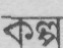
কল্প
